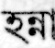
হন্না
